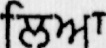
ਲਿਆ
